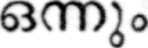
ഒന്നും
